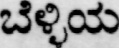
ಬೆಳ್ಳಿಯ
